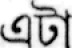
এটা
